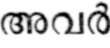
അവര്‍
